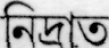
নিদ্রাত
